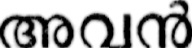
അവന്‍
